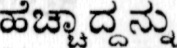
ಹೆಚ್ಚಾದ್ದನ್ನು
